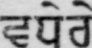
ਵਧੇਰੇ
